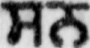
ਸਨ
